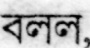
বলল,
